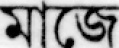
মাজে
